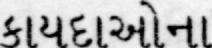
કાયદાઓના
